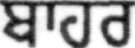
ਬਾਹਰ
